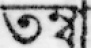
তম্বা
